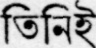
তিনিই
